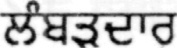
ਲੰਬੜਦਾਰ
